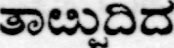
ತಾೞ್ಪುದಿದ
